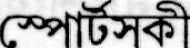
স্পোর্টসকী
